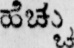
ಹೆಚ್ಚು
